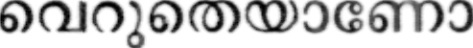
വെറുതെയാണോ
